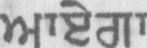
ਆਏਗਾ
